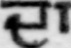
ਦਾ
